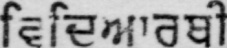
ਵਿਦਿਆਰਥੀ
